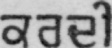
ਕਰਦੀ
